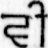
ਵੀ
